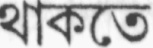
থাকতে
